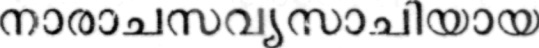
നാരാചസവ്യസാചിയായ
